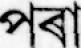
পৰা
